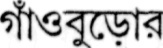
গাঁওবুড়োর
